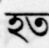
হত
